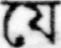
যে
